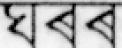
ঘৰৰ
